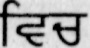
ਵਿਚ
